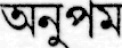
অনুপম
